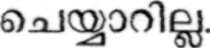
ചെയ്യാറില്ല.
